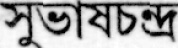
সুভাষচন্দ্র
